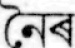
নৈৰ
